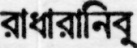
রাধারানিবু
